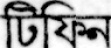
টিফিন
